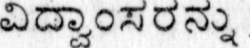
ವಿದ್ವಾಂಸರನ್ನು
